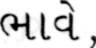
ભાવે,
